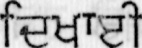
ਦਿਖਾਈ
